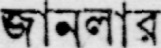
জানলার
